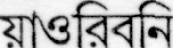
য়াওরিবনি
